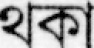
থকা
